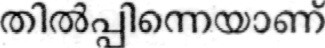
തില്‍പ്പിന്നെയാണ്
